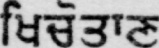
ਖਿਚੋਤਾਣ
